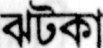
ঝটকা
